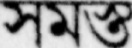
সমস্ত
